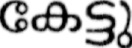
കേട്ടു
